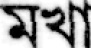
মখা
